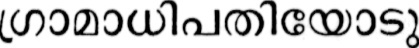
ഗ്രാമാധിപതിയോടു
